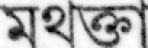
মথক্তা
